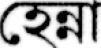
হেন্না
